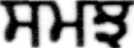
ਸਮਝ
